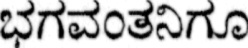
ಭಗವಂತನಿಗೂ
